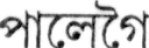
পালেগৈ
